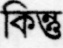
কিন্তু
